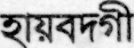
হায়বদগী
